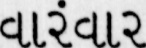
વારંવાર
